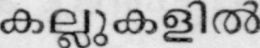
കല്ലുകളില്‍
